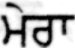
ਮੇਰਾ
